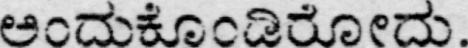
ಅಂದುಕೊಂಡಿರೋದು.
